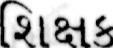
શિક્ષક
